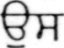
ਉਸ
